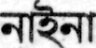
নাইনা
